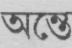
অন্তে
